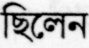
ছিলেন
